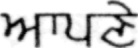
ਆਪਣੇ
